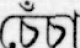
চেঁচা
